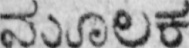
ಮೂಲಕ
